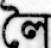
লৈ
